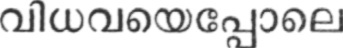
വിധവയെപ്പോലെ
